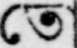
তো
